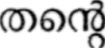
തന്റെ
